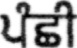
ਪੰਛੀ
